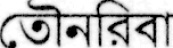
তৌনরিবা
